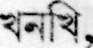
খনখি,
